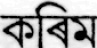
কৰিম
